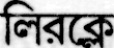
লিরক্লে
